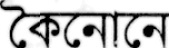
কৈনোনে
